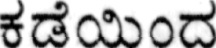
ಕಡೆಯಿಂದ
